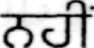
ਨਹੀਂ
